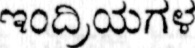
ಇಂದ್ರಿಯಗಳ
